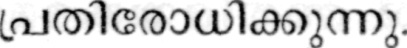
പ്രതിരോധിക്കുന്നു.
